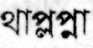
থাপ্লপ্না
